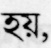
হয়,
